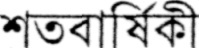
শতবার্ষিকী
